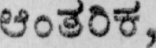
ಆಂತರಿಕ,
